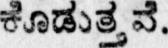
ಕೊಡುತ್ತವೆ.
